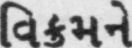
વિક્રમને
